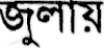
জুলায়
